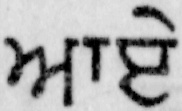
ਆਏ
